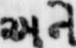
અને
